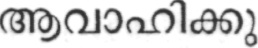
ആവാഹിക്കു
